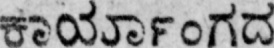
ಕಾರ್ಯಾಂಗದ
